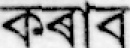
কৰাব
